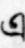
এ
